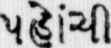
પહોંચી
